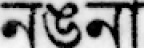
নঙনা
